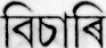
বিচাৰি
